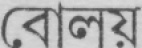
বোলয়
